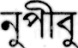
নুপীবু
